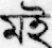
মই
